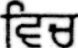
ਵਿਚ
